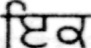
ਇਕ
